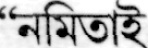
"নমিতাই
